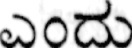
ಎಂದು
